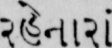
રહેનારાં
